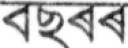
বছৰৰ
